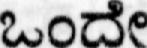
ಒಂದೇ
